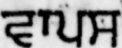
ਵਾਪਸ
